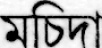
মচিদা
